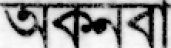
অকনবা
